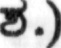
ಶ.)
